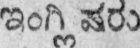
ಇಂಗ್ಲಿಷರು
